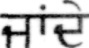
ਜਾਂਦੇ
